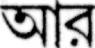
আর
